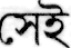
সেই
